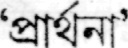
‘প্রার্থনা’
